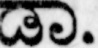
ಡಾ.
